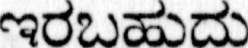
ಇರಬಹುದು
